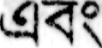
এবং
